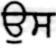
ਉਸ
